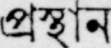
প্রস্থান
